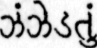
ઝંઝેડતું
